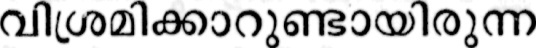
വിശ്രമിക്കാറുണ്ടായിരുന്ന
